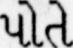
પોતે
